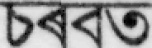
চৰবত
